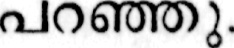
പറഞ്ഞു.
